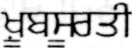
ਖ਼ੂਬਸੂਰਤੀ
